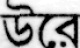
উরে
